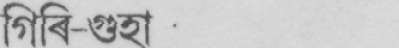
গিৰি-গুহা
